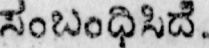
ಸಂಬಂಧಿಸಿದೆ.
